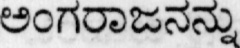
ಅಂಗರಾಜನನ್ನು
